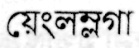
য়েংলম্লগা
